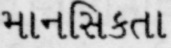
માનસિકતા
